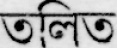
তলিত
